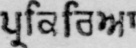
ਪ੍ਰਕਿਰਿਆ
